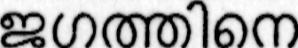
ജഗത്തിനെ
